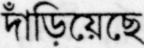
দাঁড়িয়েছে
